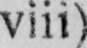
viii)
